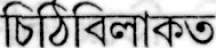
চিঠিবিলাকত
